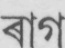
ৰাগ
